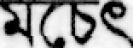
মচেৎ
